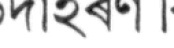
উদাহৰণ
